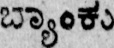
ಬ್ಯಾಂಕು
